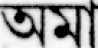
অমা
